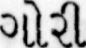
ગોરી
